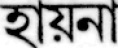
হায়না
